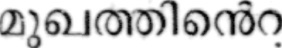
മുഖത്തിന്റെ
